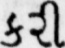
કરી
